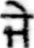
ਜੇ
